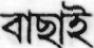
বাছাই
